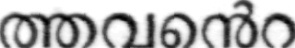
ത്തവന്റെ
